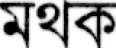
মথক
